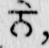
ਨੇ,
